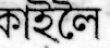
কাইলৈ
